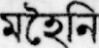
মহৈনি
